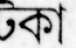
টকা
